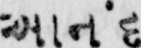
આનંદ
